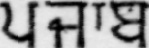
ਪਜਾਬ
